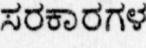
ಸರಕಾರಗಳ
